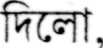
দিলো,
